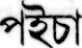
পইচা
